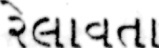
રેલાવતા
